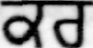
ਕਰ
